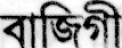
বাজিগী
